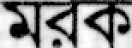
মরক
